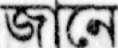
জানে
